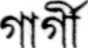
গার্গী
